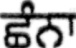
ਛੰਨਾ
